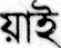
য়াই
